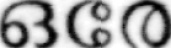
ഒരേ
